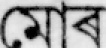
মোৰ
